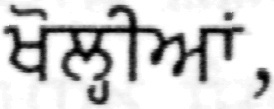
ਖੋਲ੍ਹੀਆਂ,
